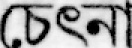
চেৎনা
